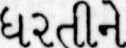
ધરતીને
